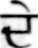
ਦੇ
